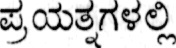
ಪ್ರಯತ್ನಗಳಲ್ಲಿ
